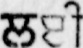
ਲਈ
